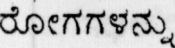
ರೋಗಗಳನ್ನು
